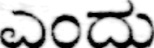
ಎಂದು
